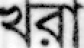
খরা
